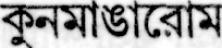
কুনমঙারোম
